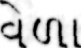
વેળા
